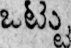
ಒಟ್ಟು
